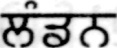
ਲੰਡਨ
